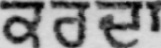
ਕਰਦਾ
